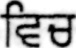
ਵਿਚ
